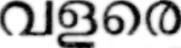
വളരെ
